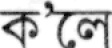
ক'লে
